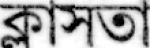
ক্লাসতা
